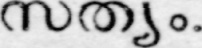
സത്യം.
